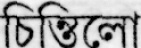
চিন্তিলো
